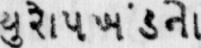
યુરોપખંડનો
